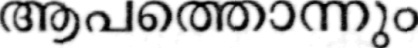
ആപത്തൊന്നും
